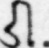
ડી.
